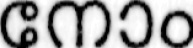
നോം
